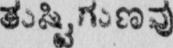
ತುಷ್ಟಿಗುಣವು
